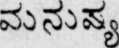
ಮನುಷ್ಯ
